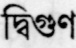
দ্বিগুণ
